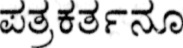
ಪತ್ರಕರ್ತನೂ
